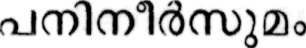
പനിനീര്‍സുമം
